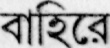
বাহিরে
